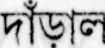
দাঁড়াল
